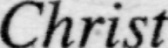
Christ
